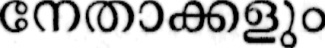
നേതാക്കളും
